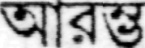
আরম্ভ
